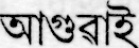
আগুৱাই
